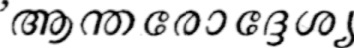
'ആന്തരോദ്ദേശ്യ
